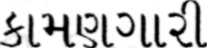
કામણગારી
